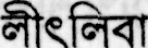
লীৎলিবা
